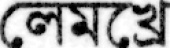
লেমখ্রে
